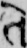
તે
